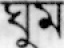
ঘুম
